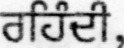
ਰਹਿੰਦੀ,
